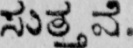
ಸುತ್ತವೆ.
